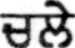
ਚਲੇ
